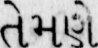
તેમણે
